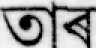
তাৰ
